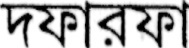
দফারফা
